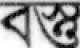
বস্তু
